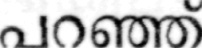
പറഞ്ഞ്
